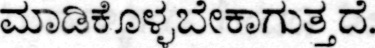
ಮಾಡಿಕೊಳ್ಳಬೇಕಾಗುತ್ತದೆ.
